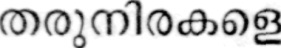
തരുനിരകളെ
